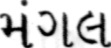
મંગલ
